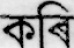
কৰি
